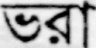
ভরা
